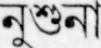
নুশুনা
